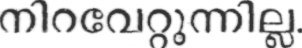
നിറവേറ്റുന്നില്ല.
